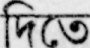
দিতে
